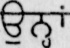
ਉਨ੍ਹਾਂ
